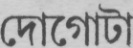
দোগোটা
